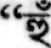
“হুঁ
